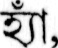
হ্যাঁ,
